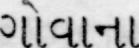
ગોવાના
